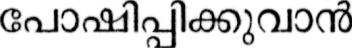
പോഷിപ്പിക്കുവാന്‍
